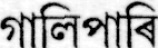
গালিপাৰি
